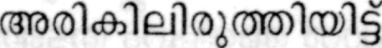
അരികിലിരുത്തിയിട്ട്
